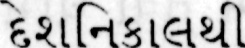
દેશનિકાલથી
